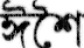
ঈশৈ
